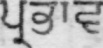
ਪ੍ਰਭਾਵ
